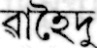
ৱাহৈদু
